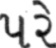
પરે
